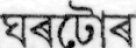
ঘৰটোৰ
